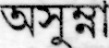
অসুম্না
